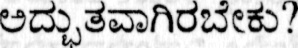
ಅದ್ಭುತವಾಗಿರಬೇಕು?
